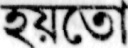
হয়তো
